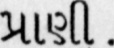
પ્રાણી.
